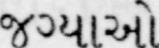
જગ્યાઓ
